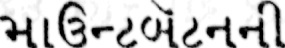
માઉન્ટબૅટનની
